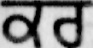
ਕਰ
